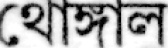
থোঙ্গাল
